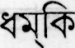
ধম্‌কি
